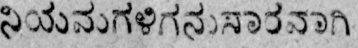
ನಿಯಮಗಳಿಗನುಸಾರವಾಗಿ
